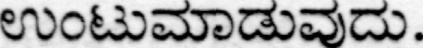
ಉಂಟುಮಾಡುವುದು.
